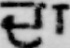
ਦਾ
